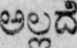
ಅಲ್ಲದೆ
